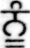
ਨੂੰ
